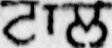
ਟਾਲ
